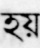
হয়
